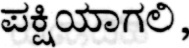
ಪಕ್ಷಿಯಾಗಲಿ,
